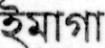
ইমাগা
